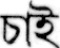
চাই
